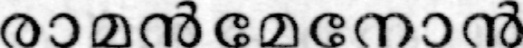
രാമന്‍മേനോന്‍
